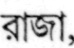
রাজা,
